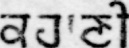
ਕਹਾਣੀ
